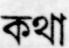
কথা
